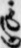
હું
